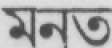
মনত
